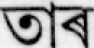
তাৰ
